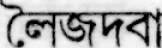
লৈজদবা
